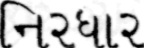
નિરધાર
